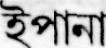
ইপানা
